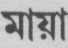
মায়া
